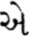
એ
